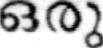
ഒരു
